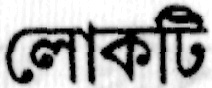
লোকটি
